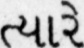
ત્યારે
